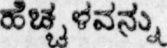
ಹೆಚ್ಚಳವನ್ನು
